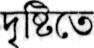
দৃষ্টিতে
